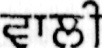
ਵਾਲੀ
